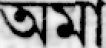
অমা
